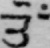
ਤੋਂ
